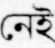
নেই
